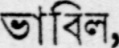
ভাবিল,
